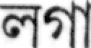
লগা
